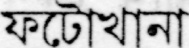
ফটোখানা
